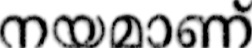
നയമാണ്
